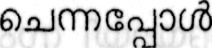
ചെന്നപ്പോള്‍
